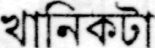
খানিকটা
